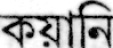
কয়ানি
